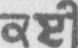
ਕਈ
